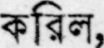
করিল,
